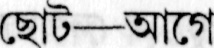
ছোট–আগে
